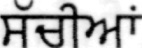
ਸੱਚੀਆਂ
